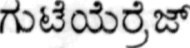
ಗುಟೆಯೆರ್ರೆಜ್
